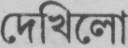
দেখিলো
